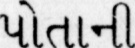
પોતાની
